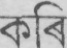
কৰি
